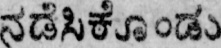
ನಡೆಸಿಕೊಂಡು
